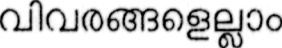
വിവരങ്ങളെല്ലാം
